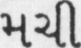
મચી
